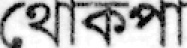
থোকপা
